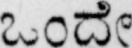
ಒಂದೇ
